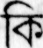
কি
